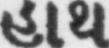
હાથ
